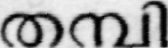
തമ്പി
